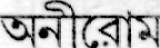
অনীরোম
